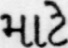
માટે
